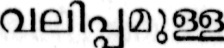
വലിപ്പമുള്ള
